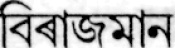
বিৰাজমান
